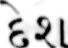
દેશ
